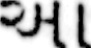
આ
